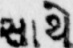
સાથે
